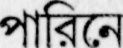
পারিনে
